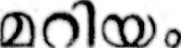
മറിയം
